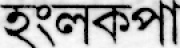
হংলকপা
